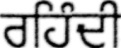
ਰਹਿੰਦੀ
